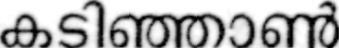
കടിഞ്ഞാണ്‍
